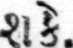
શકે.
